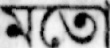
মতো
